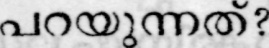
പറയുന്നത്?
